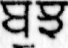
ਬੁਝ
